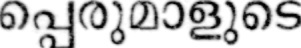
പ്പെരുമാളുടെ
